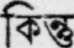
কিন্তু
